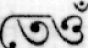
তেওঁ
